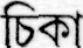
চিকা
